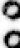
ঃ
